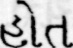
હોત
